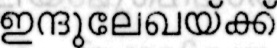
ഇന്ദുലേഖയ്ക്ക്
